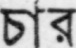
চার
